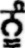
ਨੂੰ
